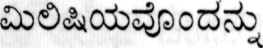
ಮಿಲಿಷಿಯವೊಂದನ್ನು
